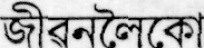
জীৱনলৈকো
